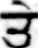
ਤੇ
